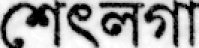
শেৎলগা
